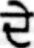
ਦੇ
